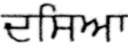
ਦਸਿਆ
